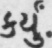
કર્યું.
